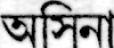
অসিনা
